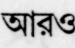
আরও
